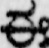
ಈ
